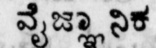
ವೈಜ್ಞಾನಿಕ
